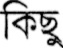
কিছু
